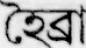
হৈব্রা
